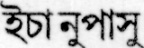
ইচানুপাসু
